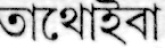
তাথোইবা
